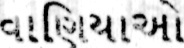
વાણિયાઓ
